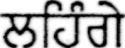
ਲਹਿੰਗੇ
